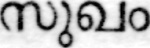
സുഖം
